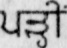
ਪੜ੍ਹੀਂ
